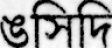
ঙসিদি
